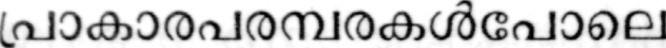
പ്രാകാരപരമ്പരകള്‍പോലെ
